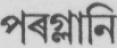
পৰগ্লানি
